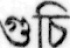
গুচি
